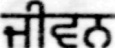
ਜੀਵਨ
